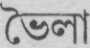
ভৈলা
